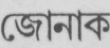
জোনাক
